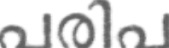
പരിപ
